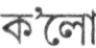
ক'লো
